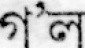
গ'ল
